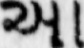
આ
